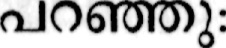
പറഞ്ഞു:
